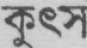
কুৎস
